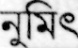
নুমিৎ
